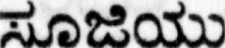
ಸೂಜಿಯು
